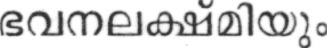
ഭവനലക്ഷ്മിയും
